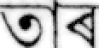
তাৰ
